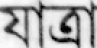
যাত্রা
